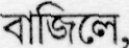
বাজিলে,
